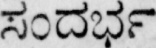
ಸಂದರ್ಭ
